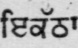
ਇਕੱਠਾ
